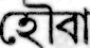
হৌবা
